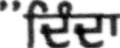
''ਦਿੰਦਾ
